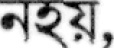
নহয়,
